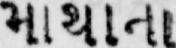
માથાના
